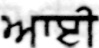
ਆਈ
